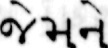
જેમને
